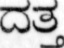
ದತ್ತ
